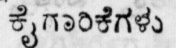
ಕೈಗಾರಿಕೆಗಳು
